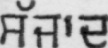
ਸੱਜਾਦ
